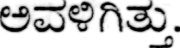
ಅವಳಿಗಿತ್ತು.
